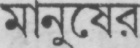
মানুষের
